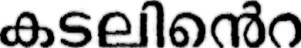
കടലിന്റെ
